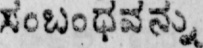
ಸಂಬಂಧವನ್ನು
